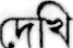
দেখি
